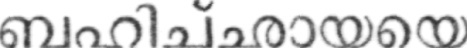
ബഹിച്ഛായയെ
